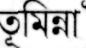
তূমিন্না
